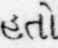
હતો
